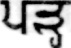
ਪੜ੍ਹ
